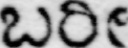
ಬರೀ
